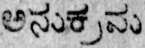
ಅನುಕ್ರಮ
